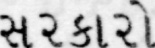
સરકારો
